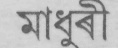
মাধুৰী
